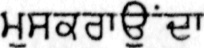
ਮੁਸਕਰਾਉਂਦਾ
